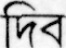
দিব
